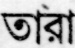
তারা
